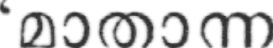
‘മാതാന്ന
